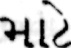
માટે
